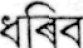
ধৰিব
